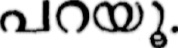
പറയൂ.
